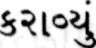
કરાવ્યું
